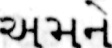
અમને
